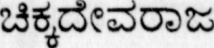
ಚಿಕ್ಕದೇವರಾಜ
